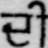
ਦੀ
